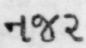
નજર
